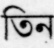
তিন
